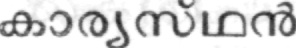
കാര്യസ്ഥന്‍
